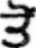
ਤੋਂ
